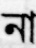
না
